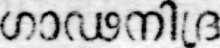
ഗാഢനിദ്ര
